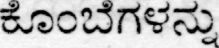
ಕೊಂಬೆಗಳನ್ನು
